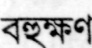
বহুক্ষণ
